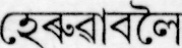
হেৰুৱাবলৈ
